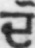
ਦੋ
